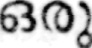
ഒരു
